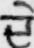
ਦੇ
